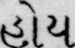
હોય
